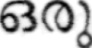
ഒരു
